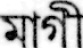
মাগী
